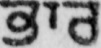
ਭਾਰ
